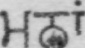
ਮਨਾਂ
